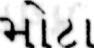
મોટા
